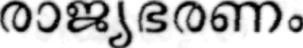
രാജ്യഭരണം
